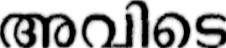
അവിടെ
